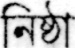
নিষ্ঠা
